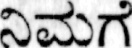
ನಿಮಗೆ
